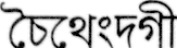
চৈথেংদগী
